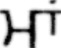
ਮਾਂ
